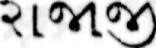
રાજાજી
